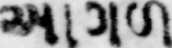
આગળ
